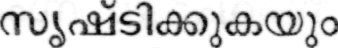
സൃഷ്ടിക്കുകയും
